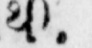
નથી.
